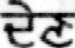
ਦੇਣ
